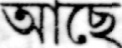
আছে
